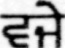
ਵਜੇ
